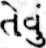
તેવું
